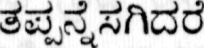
ತಪ್ಪನ್ನೆಸಗಿದರೆ
